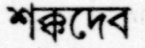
শক্কদেব
